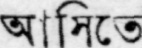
আসিতে
